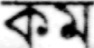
কম
